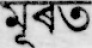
মূৰত
